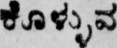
ಕೊಳ್ಳುವ
